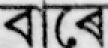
বাৰে
